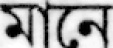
মানে
